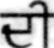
ਦੀ
